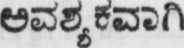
ಅವಶ್ಯಕವಾಗಿ
